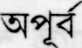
অপূর্ব
